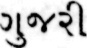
ગુજરી
